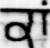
ਕਾਂ
